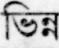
ভিন্ন
